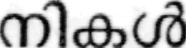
നികള്‍
